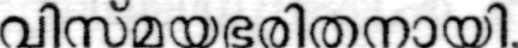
വിസ്മയഭരിതനായി.
